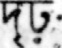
দৃঢ়়
